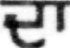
ਦਾ
